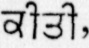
ਕੀਤੀ,
